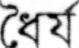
ধৈর্য
